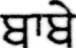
ਬਾਬੇ
